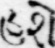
હશે
